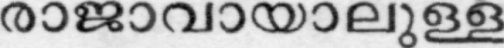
രാജാവായാലുള്ള
